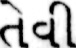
તેવી
